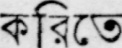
করিতে
